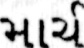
માર્ચ
